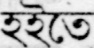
হইতে
